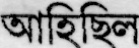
আহিছিল
